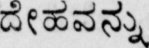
ದೇಹವನ್ನು
